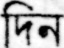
দিন
